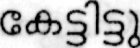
കേട്ടിട്ടു
